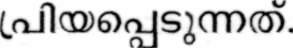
പ്രിയപ്പെടുന്നത്.
